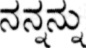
ನನ್ನನ್ನು
